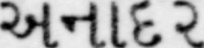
અનાદર
